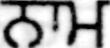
ਨਾਮ
